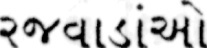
રજવાડાંઓ
